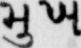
મુખ
